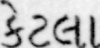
કેટલા
